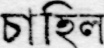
চাহিল
